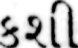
કશી
